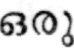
ഒരു
